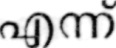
എന്ന്
